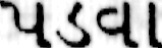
પડવા
